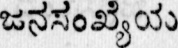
ಜನಸಂಖ್ಯೆಯ
